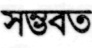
সম্ভবত
